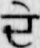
ਦੇ
